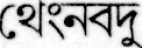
থেংনবদু
